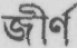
জীৰ্ণ
